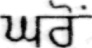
ਘਰੋਂ
